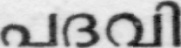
പദവി
